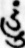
હું
